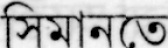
সিমানতে
